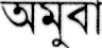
অমুবা
